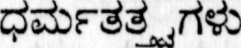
ಧರ್ಮತತ್ತ್ವಗಳು
